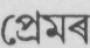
প্ৰেমৰ
